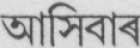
আসিবাৰ
